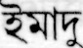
ইমাদু
